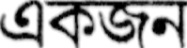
একজন
